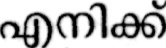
എനിക്ക്
